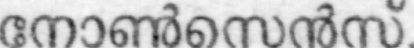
നോണ്‍സെന്‍സ്.
